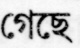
গেছে
